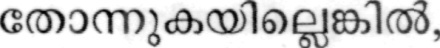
തോന്നുകയില്ലെങ്കില്‍,
